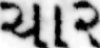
ચાર
